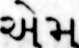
એમ
